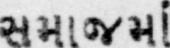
સમાજમાં
